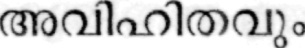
അവിഹിതവും
